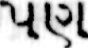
પણ
